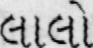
લાલો
